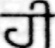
ਹੀ
